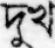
দুখ
